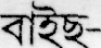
বাইছ-
